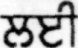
ਲਈ
